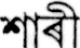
শাৰী
